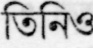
তিনিও
